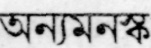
অন্যমনস্ক
